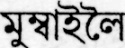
মুম্বাইলৈ
